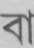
বা
